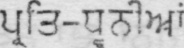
ਪ੍ਰਤਿ-ਧ੍ਵਨੀਆਂ
